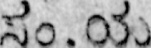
ಸಂ.ಯ
